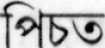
পিচত
